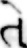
તે
